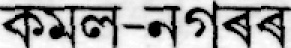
কমল-নগৰৰ
